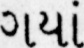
ગયાં
